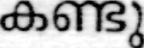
കണ്ടു
